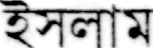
ইসলাম
